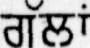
ਗੱਲਾਂ
